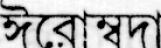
ঈরোম্বদা
